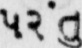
પરંતુ
